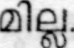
മില്ല.
